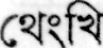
থেংখি
